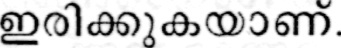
ഇരിക്കുകയാണ്.
